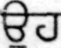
ਉਹ
